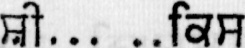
ਸੀ.....ਕਿਸ
